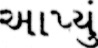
આપ્યું
